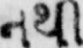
નથી
